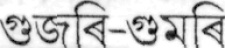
গুজৰি-গুমৰি
